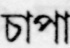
চাপা
